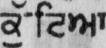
ਕੁੱਟਿਆ
